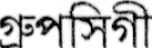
গ্রুপসিগী
